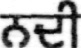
ਨਦੀ
